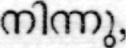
നിന്നു,
